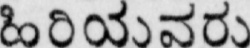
ಹಿರಿಯವರು
